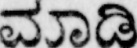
ಮಾಡಿ
